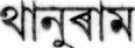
থানুৰাম
